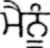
ਮੈਨੂੰ
